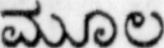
ಮೂಲ
